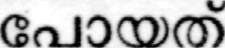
പോയത്
